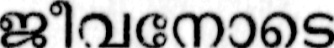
ജീവനോടെ
